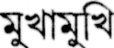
মুখামুখি
